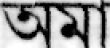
অমা
